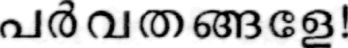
പര്‍വതങ്ങളേ!
